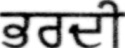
ਭਰਦੀ
